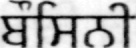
ਬੌਸਿਨੀ
